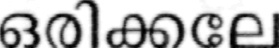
ഒരിക്കലേ
